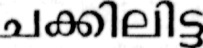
ചക്കിലിട്ട
